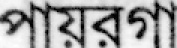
পায়রগা
